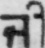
ਜੀ
